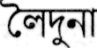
লৈদুনা
